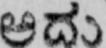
ಅದು
